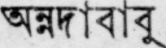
অন্নদাবাবু
